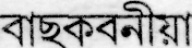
বাছকবনীয়া
